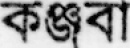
কঞ্জবা
